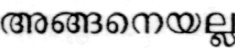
അങ്ങനെയല്ല
